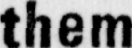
them
